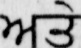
ਅਤੇ
